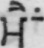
ਮੈਂ
